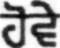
ਹੋਵੇ
